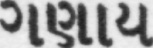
ગણાય
